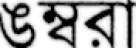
ঙম্বরা
